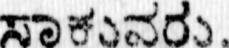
ಸಾಕುವರು.
